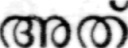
അത്
